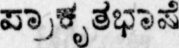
ಪ್ರಾಕೃತಭಾಷೆ
